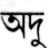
অদু
